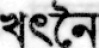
খৎনৈ
